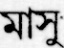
মাসু
